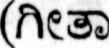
(ಗೀತಾ
